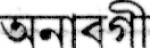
অনাবগী
